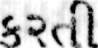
કરતી
